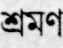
শ্রমণ
